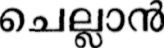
ചെല്ലാന്‍
